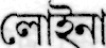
লোইনা
